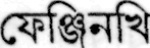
ফেঞ্জিনখি
